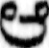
ಆ
